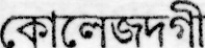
কোলেজদগী
